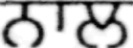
ਨਾਲ
